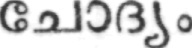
ചോദ്യം
